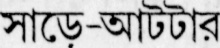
সাড়ে-আটটার
